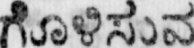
ಗೊಳಿಸುವ
